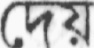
দেয়
